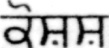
ਕੋਸ਼ਸ਼
